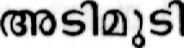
അടിമുടി
